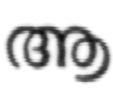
ആ
